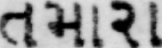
તમારા
